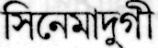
সিনেমাদুগী
